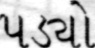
પડ્યો
